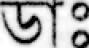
ডাঃ
